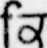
ਕਿ
